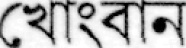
খোংবান
